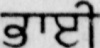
ਭਾਈ
